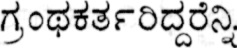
ಗ್ರಂಥಕರ್ತರಿದ್ದರೆನ್ನಿ.
